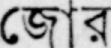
জোর
